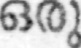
ഒരു
